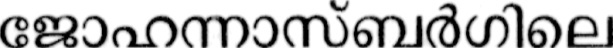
ജോഹന്നാസ്ബര്‍ഗിലെ
